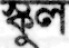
স্কুল
